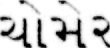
ચોમેર
